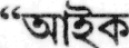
"আইক
